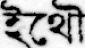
ইথৌ
